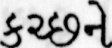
કચ્છને
